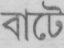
বাটে
